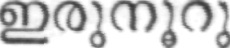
ഇരുനൂറു
